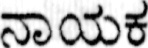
ನಾಯಕ
